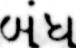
બંધ
